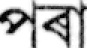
পৰা
